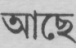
আছে
